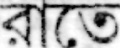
রাতে
